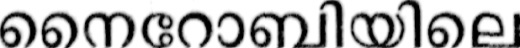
നൈറോബിയിലെ
